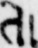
તો
